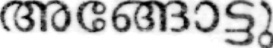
അങ്ങോട്ടു
